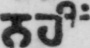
ਨਹੀਂ
